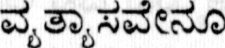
ವ್ಯತ್ಯಾಸವೇನೂ
